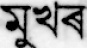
মুখৰ
